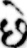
છે
